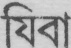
যিবা
